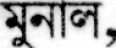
মুনাল,
